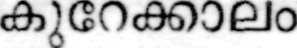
കുറേക്കാലം
